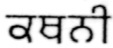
ਕਥਨੀ
